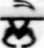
ਲੈ
